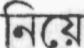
নিয়ে
